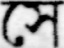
সে
